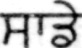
ਸਾਡੇ
